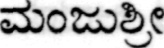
ಮಂಜುಶ್ರೀ
